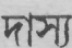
দাস্য
